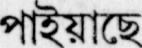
পাইয়াছে
